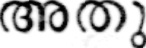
അതു
